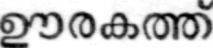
ഊരകത്ത്
